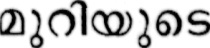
മുറിയുടെ
